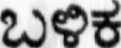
ಬಳಿಕ
